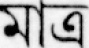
মাত্র
